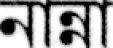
নান্না
